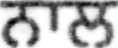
ਨਾਲ
